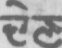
ਦੇਣ
